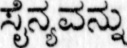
ಸೈನ್ಯವನ್ನು
